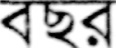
বছর
